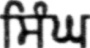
ਸਿੰਘ
